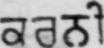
ਕਰਨੀ
